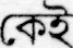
কেই
